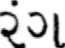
રંગ
